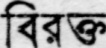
বিরক্ত
